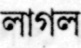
লাগল
